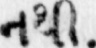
નથી.
